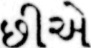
છીએ
